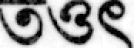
তওৎ
